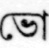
ভো
